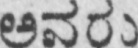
ಅವರು
